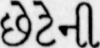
છેટેની
